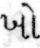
ખો
